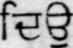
ਦਿਉ
